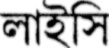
লাইসি
